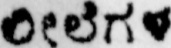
ಲೀಲೆಗಳ
